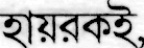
হায়রকই,
